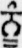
ਨੂੰ
